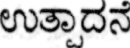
ಉತ್ಪಾದನೆ
